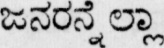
ಜನರನ್ನೆಲ್ಲಾ
